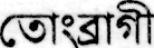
তোংব্রাগী
